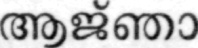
ആജ്ഞാ
